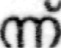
ന്ന്
